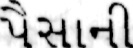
પૈસાની
